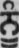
ਨੂੰ
